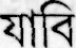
যাবি
